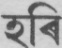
হৰি
